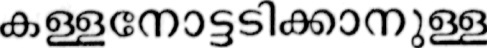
കള്ളനോട്ടടിക്കാനുള്ള
